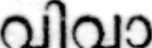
വിവാ
